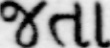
જતા
